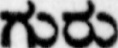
ಗುರು
